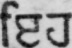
ਇਹ
